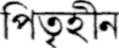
পিতৃহীন
